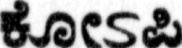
ಕೋsಪಿ
